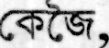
কেজৈ,
